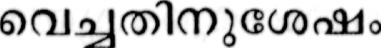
വെച്ചതിനുശേഷം
